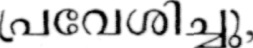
പ്രവേശിച്ചു,
